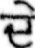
ਦੇ
